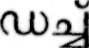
ഡച്ച്
